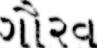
ગૌરવ
